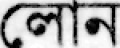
লোন
